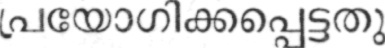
പ്രയോഗിക്കപ്പെട്ടതു
